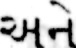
અને
